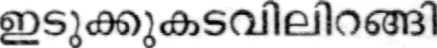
ഇടുക്കുകടവിലിറങ്ങി
